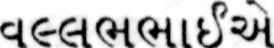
વલ્લભભાઈએ
